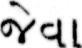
જેવા
